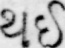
થઈ
